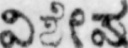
ವಿಶೇಷ
